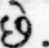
છે.
